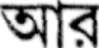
আর
